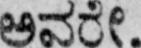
ಅವರೇ.
